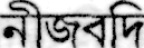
নীজবদি
